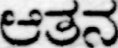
ಆತನ
